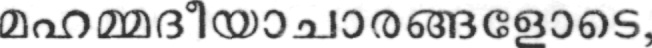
മഹമ്മദീയാചാരങ്ങളോടെ,
